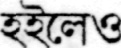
হইলেও
